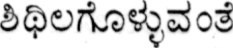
ಶಿಥಿಲಗೊಳ್ಳುವಂತೆ
